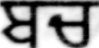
ਬਚ
